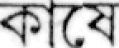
কাষে
